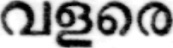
വളരെ
